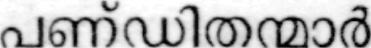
പണ്ഡിതന്മാര്‍
